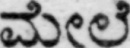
ಮೇಲೆ
